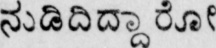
ನುಡಿದಿದ್ದಾರೋ
